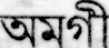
অমগী
